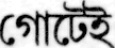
গোটেই
